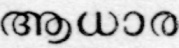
ആധാര
